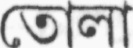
তোলা
